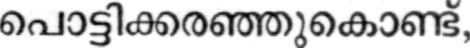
പൊട്ടിക്കരഞ്ഞുകൊണ്ട്,
